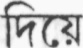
দিয়ে
